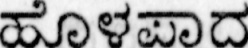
ಹೊಳಪಾದ
